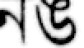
নঙ
